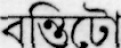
বন্তিটো
